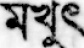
মখুৎ
